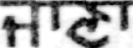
ਜਾਣਾ
